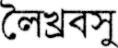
লৈখ্রবসু
